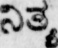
ನಿತ್ಯ
